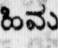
ಹಿಮ
